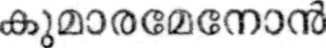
കുമാരമേനോന്‍
